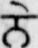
ਨੇ
